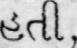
હતી,
